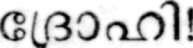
ദ്രോഹി!
